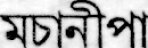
মচানীপা
